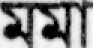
মমা
